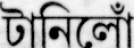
টানিলোঁ
